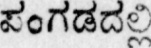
ಪಂಗಡದಲ್ಲಿ
